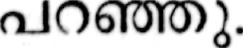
പറഞ്ഞു.
